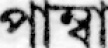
পাম্বা
